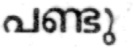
പണ്ടു
